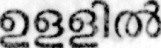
ഉളളില്‍
